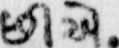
છીએ.
